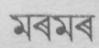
মৰমৰ
